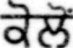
ਕੋਲੋਂ
